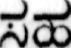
ಸಹ
